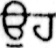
ਉਹ
